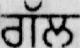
ਗੱਲ
